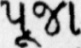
પૂજા
